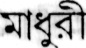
মাধুরী
